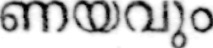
ണയവും
